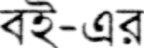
বই-এর
